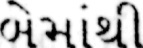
બેમાંથી
